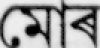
মোৰ
